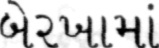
બેરખામાં
